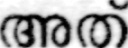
അത്
